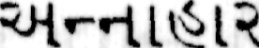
અન્નાહાર
